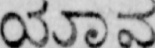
ಯಾವ
